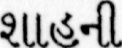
શાહની
